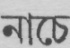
নাচে
